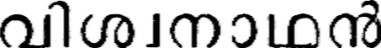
വിശ്വനാഥന്‍
